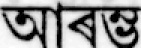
আৰম্ভ
